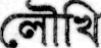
লৌখি
